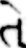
તે
